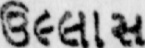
ઉલ્લાસ
